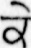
ਕੇ
